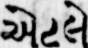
એટલે
